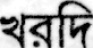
খরদি
